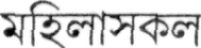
মহিলাসকল
